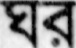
ঘর
